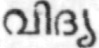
വിദ്യ
